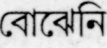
বোঝেনি
